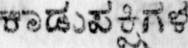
ಕಾಡುಪಕ್ಷಿಗಳ
